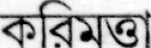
করিমত্তা
